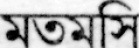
মতমসি
